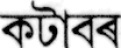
কটাবৰ
